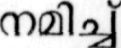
നമിച്ച്
